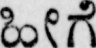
ಹೀಗೆ
